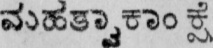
ಮಹತ್ವಾಕಾಂಕ್ಷೆ
